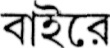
বাইরে
